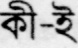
কী-ই
